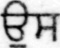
ਉਸ
